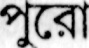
পুরো
